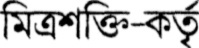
মিত্রশক্তি-কর্তৃ
